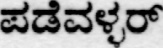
ಪಡೆವಳ್ಳರ್
